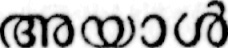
അയാള്‍
